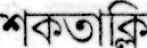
শকতাক্লি
